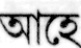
আহে
